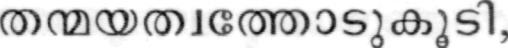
തന്മയത്വത്തോടുകൂടി,
